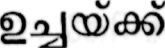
ഉച്ചയ്ക്ക്
